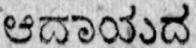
ಆದಾಯದ
